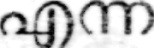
എന്ന
